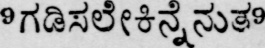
9ಗಡಿಸಲೇಕಿನ್ನೆನುತ9
